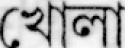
খোলা
